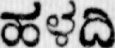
ಹಳದಿ
